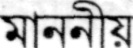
মাননীয়
